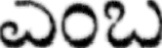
ಎಂಬ
